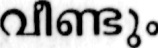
വീണ്ടും
